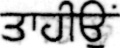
ਤਾਹੀਉਂ
